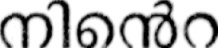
നിന്റെ
